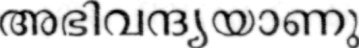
അഭിവന്ദ്യയാണു
